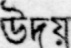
উদয়
